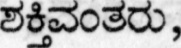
ಶಕ್ತಿವಂತರು,
